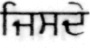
ਜਿਸਦੇ
